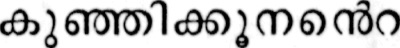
കുഞ്ഞിക്കൂനന്റെ
